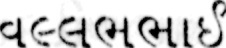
વલ્લભભાઈ
